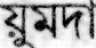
য়ুমদা
